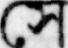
সে
